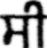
ਸੀ
